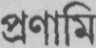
প্ৰণামি
